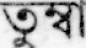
তুম্বা
